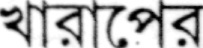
খারাপের
